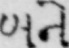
બને
